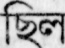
ছিল
